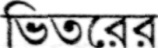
ভিতরের
